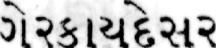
ગેરકાયદેસર
